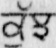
ਕੁੱਝ
